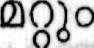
മറ്റും
